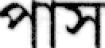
পাস
